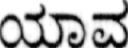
ಯಾವ
